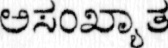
ಅಸಂಖ್ಯಾತ
